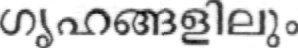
ഗൃഹങ്ങളിലും
